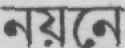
নয়নে
